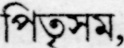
পিতৃসম,
